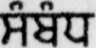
ਸੰਬੰਧ
